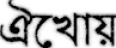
ঐখোয়
